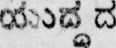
ಯುದ್ಧದ
